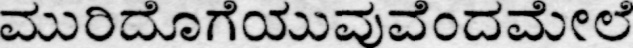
ಮುರಿದೊಗೆಯುವುವೆಂದಮೇಲೆ
